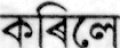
কৰিলে
